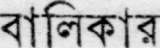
বালিকার
